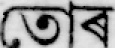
তোৰ
